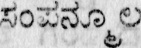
ಸಂಪನ್ಮೂಲ
